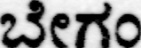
ಬೇಗಂ
